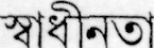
স্বাধীনতা
